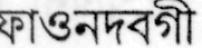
ফাওনদবগী
